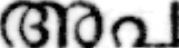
അപ
